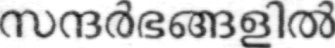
സന്ദര്‍ഭങ്ങളില്‍
